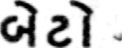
બેટો
